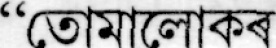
"তোমালোকৰ
